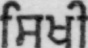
ਸਿਖੀ
